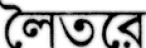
লৈতরে
